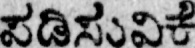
ಪಡಿಸುವಿಕೆ
